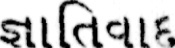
જ્ઞાતિવાદ
